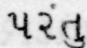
પરંતુ
